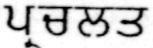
ਪ੍ਰਚਲਤ
